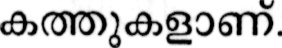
കത്തുകളാണ്.
